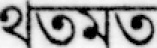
থতমত
